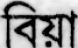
বিয়া
